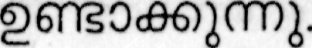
ഉണ്ടാക്കുന്നു.
